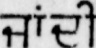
ਜਾਂਦੀ
